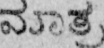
ಮಾತ್ರ
